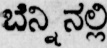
ಬೆನ್ನಿನಲ್ಲಿ
